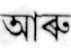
আৰু
